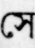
সে
